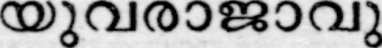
യുവരാജാവു
